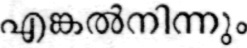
എങ്കല്‍നിന്നും
